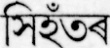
সিহঁতৰ
